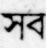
সব
